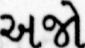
અજો
